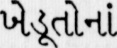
ખેડૂતોનાં
